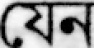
যেন
